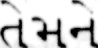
તેમને
